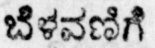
ಬೆಳವಣಿಗೆ
